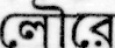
লৌরে
